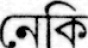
নেকি
